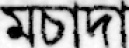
মচাদা
